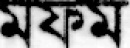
মফম
